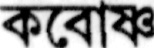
কবোষ্ণ
